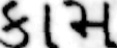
કામ
